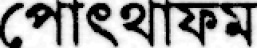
পোৎথাফম
